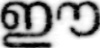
ഈ
